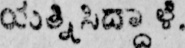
ಯತ್ನಿಸಿದ್ದಾಳೆ.
